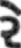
રે
